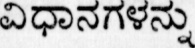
ವಿಧಾನಗಳನ್ನು
